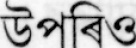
উপৰিও
